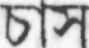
চাস
